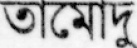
তামোদু
